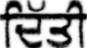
ਦਿੱਤੀ
